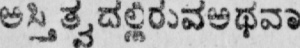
ಅಸ್ತಿತ್ವದಲ್ಲಿರುವಅಥವಾ
